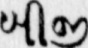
બીજી
